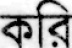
করি
